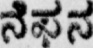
ನೆಫನ
